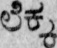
ಲೆಕ್ಕ
